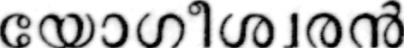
യോഗീശ്വരന്‍
